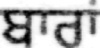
ਬਾਰਾਂ
